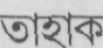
তাহাক
